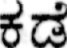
ಕಡೆ
